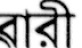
ৱারী
